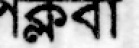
পক্লবা
